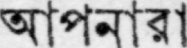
আপনারা
